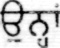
ਉਨ੍ਹਾਂ
